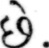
છે.
